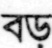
বড়
